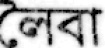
লৈবা
